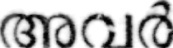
അവര്‍
